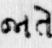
જાતે
